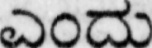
ಎಂದು
